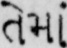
તેમાં
